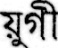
য়ুগী
